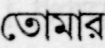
তোমার
